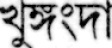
খুঙ্গংদা
